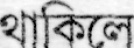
থাকিলে
